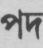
পদ
